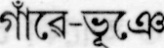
গাঁৱে-ভূঞে
